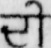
ਦੀ
